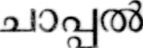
ചാപ്പല്‍
